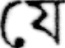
যে
